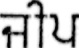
ਜੀਪ
